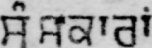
ਸੰਸਕਾਰਾਂ
